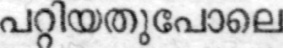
പറ്റിയതുപോലെ
